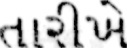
તારીખે
